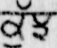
ਕੁੱਝ
